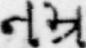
નમ્ર
